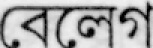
বেলেগ
